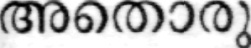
അതൊരു
